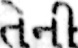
તેની
